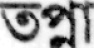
তপ্না
